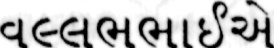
વલ્લભભાઈએ
